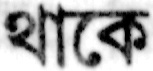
থাকে
